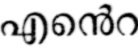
എന്റെ
